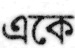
একে
